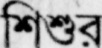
শিশুর
